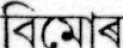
বিমোৰ
